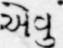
એવું
